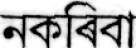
নকৰিবা
